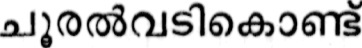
ചൂരല്‍വടികൊണ്ട്
